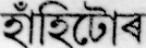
হাঁহিটোৰ
